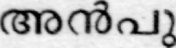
അന്‍പു
